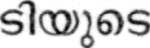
ടിയുടെ
